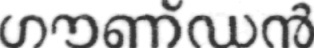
ഗൌണ്ഡന്‍
